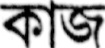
কাজ
